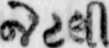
જેટલી
